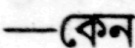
–কেন
